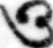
ও
